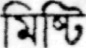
মিষ্টি
